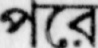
পরে
